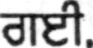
ਗਈ,
